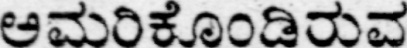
ಅಮರಿಕೊಂಡಿರುವ
